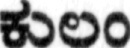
ಕುಲಂ
